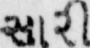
સારી
